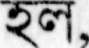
হল,
